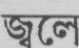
জ্বলে
